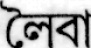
লৈবা
